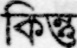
কিন্তু
